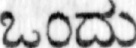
ಒಂದು
